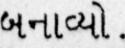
બનાવ્યો.
